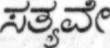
ಸತ್ಯವೇ
